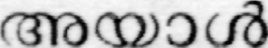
അയാള്‍
